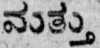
ಮತ್ತು
